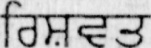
ਰਿਸ਼ਵਤ
